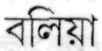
বলিয়া
